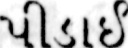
પીડાઈ
